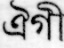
ঐগী
